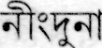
নীংদুনা
